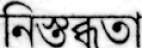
নিস্তব্ধতা
